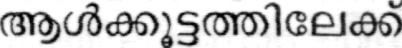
ആള്‍ക്കൂട്ടത്തിലേക്ക്
